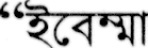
“ইবেম্মা
